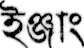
ইঞ্জাং
